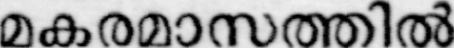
മകരമാസത്തില്‍
